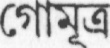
গোমূত্র
